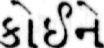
કોઈને
